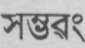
সম্ভৱং
